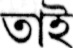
তাই
